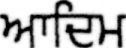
ਆਦਿਮ
